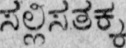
ಸಲ್ಲಿಸತಕ್ಕ
